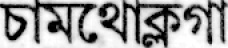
চামথোক্লগা
